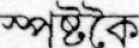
স্পষ্টকৈ
